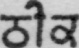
ਠੀਕ
